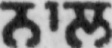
ਨਾਲ
